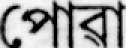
পোৱা
